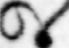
જ
